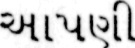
આપણી
